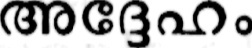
അദ്ദേഹം
